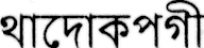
থাদোকপগী
